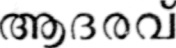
ആദരവ്
